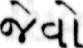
જેવો
